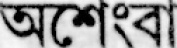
অশেংবা
